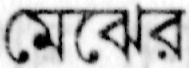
মেঝের
